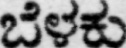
ಬೆಳಕು
